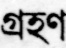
গ্রহণ
